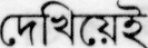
দেখিয়েই
